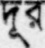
দূর
